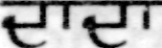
ਦਾਦਾ
